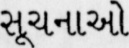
સૂચનાઓ
